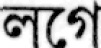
লগে
